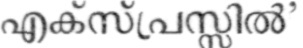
എക്ര്‌സ്‌പസ്സില്‍’
